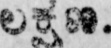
ಲಕ್ಷಣ.
